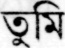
তুমি
